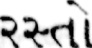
રસ્તો
